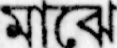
মাঝে
